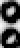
ঃ
